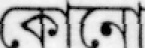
কোনো
